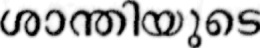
ശാന്തിയുടെ
